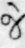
જે
